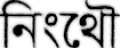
নিংথৌ
